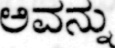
ಅವನ್ನು
